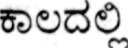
ಕಾಲದಲ್ಲಿ
